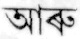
আৰু
